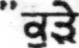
''ਕੁੜੇ
